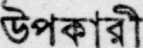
উপকারী
